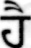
ਹੈ
